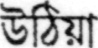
উঠিয়া
